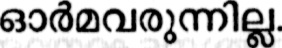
ഓര്‍മവരുന്നില്ല.
